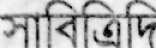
সাবিত্রিদি
